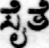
ಸೈತೆ
